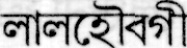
লালহৌবগী
